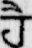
ਹੈ
